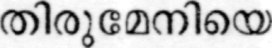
തിരുമേനിയെ
